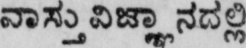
ವಾಸ್ತುವಿಜ್ಞಾನದಲ್ಲಿ
